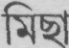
মিছা
